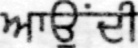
ਆਉਂਦੀ
